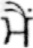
ਮੈਂ
